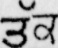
ਤੱਕ
